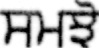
ਸਮਝੋ
